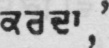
ਕਰਦਾ,'
